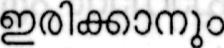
ഇരിക്കാനും
